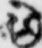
છે
